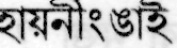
হায়নীংঙাই
